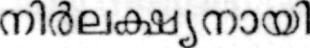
നിര്‍ലക്ഷ്യനായി
